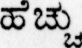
ಹೆಚ್ಚು
